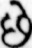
છે
